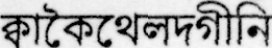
ক্বাকৈথেলদগীনি
